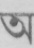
অ
